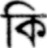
কি
